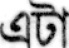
এটা
